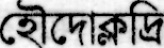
হৌদোক্লদ্রি
